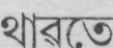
থাৱতে
